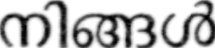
നിങ്ങള്‍
